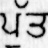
ਪੁੱਤ
